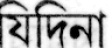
যিদিনা
